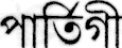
পার্তিগী
